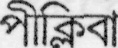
পীক্লিবা
